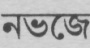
নভজে
